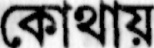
কোথায়
